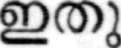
ഇതു
